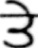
ਤੇ
